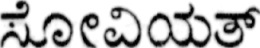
ಸೋವಿಯತ್
